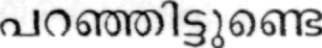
പറഞ്ഞിട്ടുണ്ടെ
